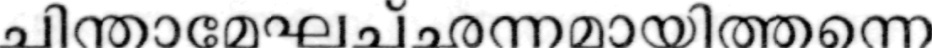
ചിന്താമേഘച്ഛന്നമായിത്തന്നെ
